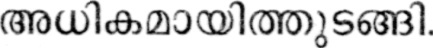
അധികമായിത്തുടങ്ങി.
